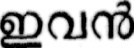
ഇവന്‍
